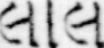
લાલ
